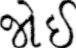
જોઈ
